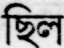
ছিল
